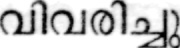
വിവരിച്ചു
